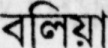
বলিয়া
